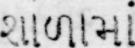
શાળામાં
